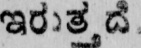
ಇರುತ್ತದೆ.
